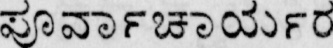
ಪೂರ್ವಾಚಾರ್ಯರ
